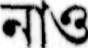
নাও
